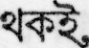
থকই,
